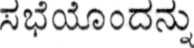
ಸಭೆಯೊಂದನ್ನು
